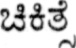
ಚಿಕಿತ್ಸೆ
